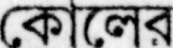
কোলের
